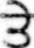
ਤੇ
